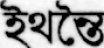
ইথন্তৈ
